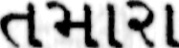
તમારા
